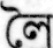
লৈ
